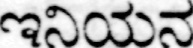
ಇನಿಯನ
